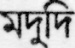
মদুদি
